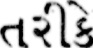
તરીકે
